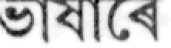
ভাষাৰে
